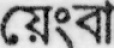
য়েংবা
